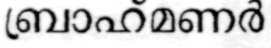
ബ്രാഹ്മണര്‍
